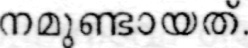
നമുണ്ടായത്.
